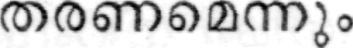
തരണമെന്നും
